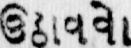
ઉઠાવવો
